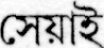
সেয়াই
